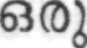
ഒരു
